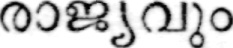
രാജ്യവും
